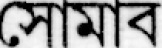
সোমাব
